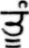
ਤੂੰ
